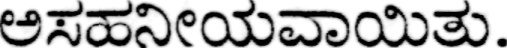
ಅಸಹನೀಯವಾಯಿತು.
